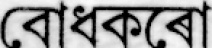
বোধকৰো
